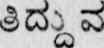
ತಿದ್ದುವ
